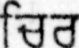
ਚਿਰ
